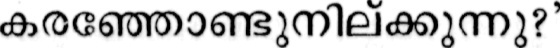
കരഞ്ഞോണ്ടുനില്ക്കുന്നു?’
